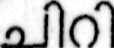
ചിറി
